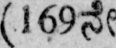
(169ನೇ
